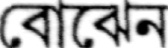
বোঝেন
